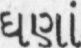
ઘણાં
